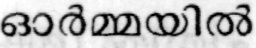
ഓര്‍മ്മയില്‍
